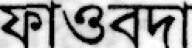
ফাওবদা
